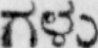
ಗಳು
